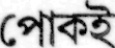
পোকই
